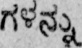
ಗಳನ್ನು
